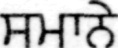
ਸਮਾਨੇ
